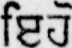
ਇਹੋ
